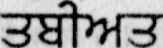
ਤਬੀਅਤ
